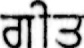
ਗੀਤ
